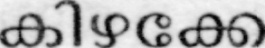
കിഴക്കേ
